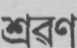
শ্ৰৱণ
